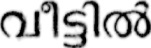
വീട്ടില്‍
